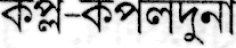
কপ্ল-কপলদুনা
